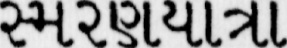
સ્મરણયાત્રા
